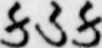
કડક
